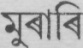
মুৰাৰি
